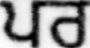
ਪਰ
